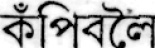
কঁপিবলৈ
